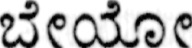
ಬೇಯೋ
